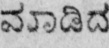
ಮಾಡಿದ
